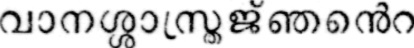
വാനശ്ശാസ്ത്രജ്ഞന്റെ
